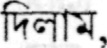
দিলাম,
